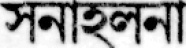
সনাহলনা
